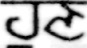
ਹੁਣ
